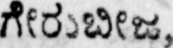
ಗೇರುಬೀಜ,
